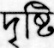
দৃষ্টি
